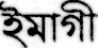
ইমাগী
